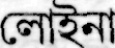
লোইনা
